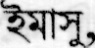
ইমাসু,
